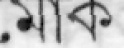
মোক
